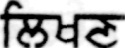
ਲਿਖਣ
